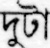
দুটা
